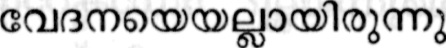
വേദനയെയല്ലായിരുന്നു
